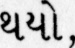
થયો,
